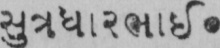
સુત્રધારભાઈ.
